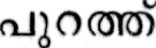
പുറത്ത്
